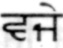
ਵਜੇ
